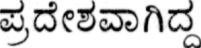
ಪ್ರದೇಶವಾಗಿದ್ದ
